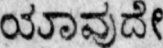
ಯಾವುದೇ
